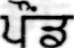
ਪੌਂਡ
